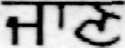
ਜਾਣ
